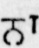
ਨਾ
